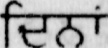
ਦਿਨਾਂ
